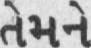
તેમને
